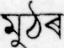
মুঠৰ
